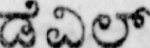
ಡೆವಿಲ್
